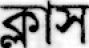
ক্লাস
